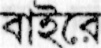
বাইরে
